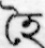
হৈ
